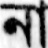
না
